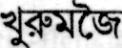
খুরুমজৈ
